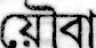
য়ৌবা
